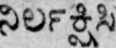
ನಿರ್ಲಕ್ಷಿಸಿ
